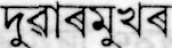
দুৱাৰমুখৰ
